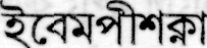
ইবেমপীশক্না
